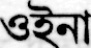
ওইনা
